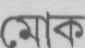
মোক
